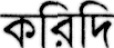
করিদি
